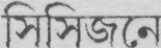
সিসিজনে
